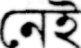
নেই
